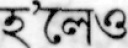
হ'লেও
